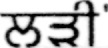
ਲੜੀ'
